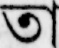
তা
